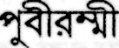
পুবীরম্মী
